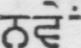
ਨਵੇਂ
